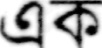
এক
